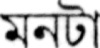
মনটা
